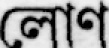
লোণ
